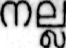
നല്ല
